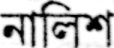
নালিশ
